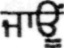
ਜਾਊਂ
